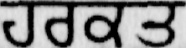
ਹਰਕਤ
